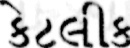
કેટલીક
